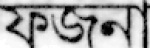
ফজনা
